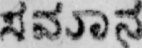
ಸಮಾನ
